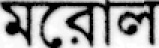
মরোল
